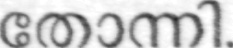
തോന്നി.
